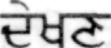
ਦੇਖਣ
